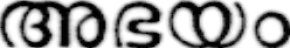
അഭയം
